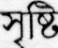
সৃষ্টি
